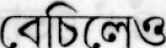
বেচিলেও
